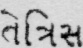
તેત્રિસ
